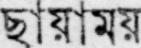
ছায়াময়
